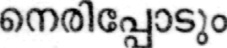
നെരിപ്പോടും
